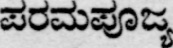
ಪರಮಪೂಜ್ಯ
